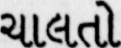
ચાલતો
